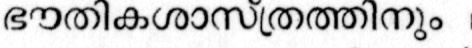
ഭൌതികശാസ്ത്രത്തിനും
